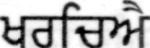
ਖਰਚਿਐ
